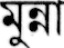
মুন্না
